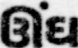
ઊંઘ
